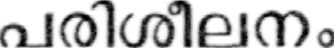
പരിശീലനം
